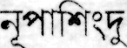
নূপাশিংদু
